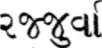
રજ્જુર્વા
